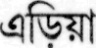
এড়িয়া
